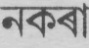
নকৰা
